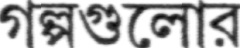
গল্পগুলোর
